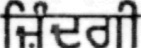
ਜ਼ਿੰਦਗੀ
